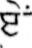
ਏਂ
